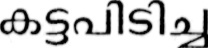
കട്ടപിടിച്ച
